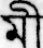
মী
